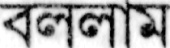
বললাম
